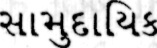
સામુદાયિક
